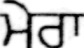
ਮੇਰਾ
